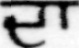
ਦਾ
